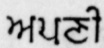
ਅਪਣੀ
